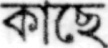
কাছে
